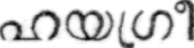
ഹയഗ്രീ
